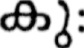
കു:
